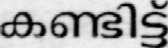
കണ്ടിട്ട്
